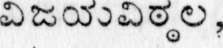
ವಿಜಯವಿಠ್ಠಲ,
